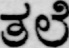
ತಲೆ
